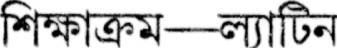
শিক্ষাক্রম–ল্যাটিন
